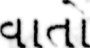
વાનો
